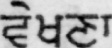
ਵੇਖਣਾ
